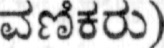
ವಣಿಕರು)
